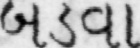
બડવા
